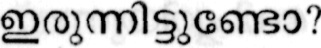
ഇരുന്നിട്ടുണ്ടോ?
